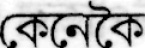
কেনেকৈ
